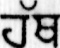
ਹੱਥ
